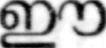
ഈ
